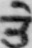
ਤੇ
